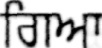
ਗਿਆ
